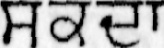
ਸਕਦਾ
